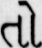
તો
